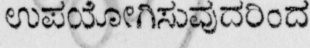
ಉಪಯೋಗಿಸುವುದರಿಂದ
